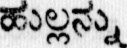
ಹುಲ್ಲನ್ನು
